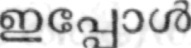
ഇപ്പോള്‍
